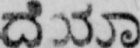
ದೆಯಾ
